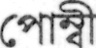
পোম্বী
